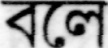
বলে
